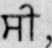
ਸੀ,
